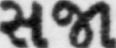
સજા
